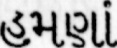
હમણાં
